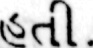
હતી.
